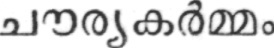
ചൌര്യകര്‍മ്മം
